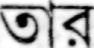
তার
